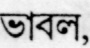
ভাবল,
